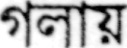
গলায়
